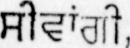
ਸੀਵਾਂਗੀ,
